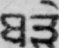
ਬੜੇ
